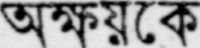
অক্ষয়কে
